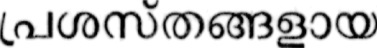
പ്രശസ്തങ്ങളായ
